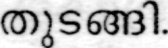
തുടങ്ങി.
